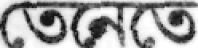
তেনেতে
